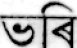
ভৰি
